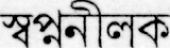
স্বপ্ননীলক
